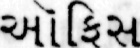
ઑફિસ
